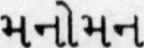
મનોમન
